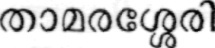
താമരശ്ശേരി
